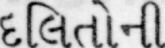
દલિતોની
